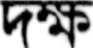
দক্ষ
